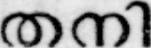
തനി
